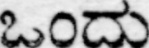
ಒಂದು
